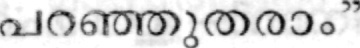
പറഞ്ഞുതരാം"
